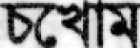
চখোম
